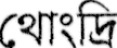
থোংদ্রি
